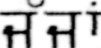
ਜੱਜਾਂ
